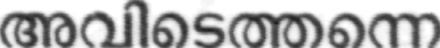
അവിടെത്തന്നെ
